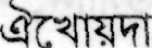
ঐখোয়দা
